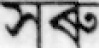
সৰু
